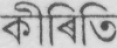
কীৰিতি
